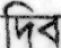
দিব
